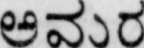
ಅಮರ
